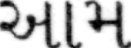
આમ
